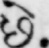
છે.
